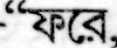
“ফরে,
